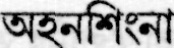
অহনশিংনা
